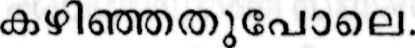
കഴിഞ്ഞതുപോലെ.
